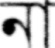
না
